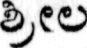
ಶ್ರೀಲ
